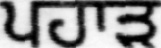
ਪਹਾੜ
